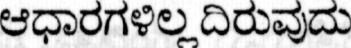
ಆಧಾರಗಳಿಲ್ಲದಿರುವುದು
